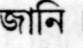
জানি
